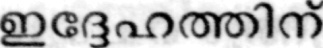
ഇദ്ദേഹത്തിന്
